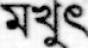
মখুৎ
